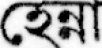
হেন্না
